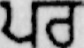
ਪਰ
